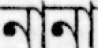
নানা
